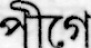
পীগে
